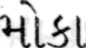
મોકા
